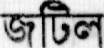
জটিল
